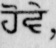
ਹੋਵੇ,
